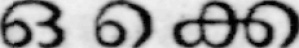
ഒക്കെ
